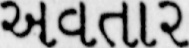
અવતાર
